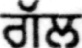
ਗੱਲ
